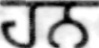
ਹਨ
